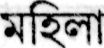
মহিলা
